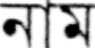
নাম
